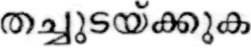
തച്ചുടയ്ക്കുക
